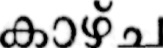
കാഴ്ച
